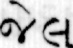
જેલ
